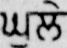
ਘੁਲੇ
